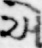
એ
